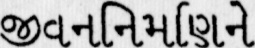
જીવનનિર્માણને
